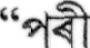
"পৰী
